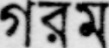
গরম
